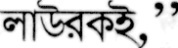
লাউরকই,”
